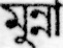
মুন্না
